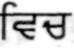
ਵਿਚ
